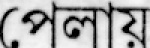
পেলায়
